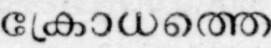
ക്രോധത്തെ
